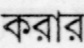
করার
